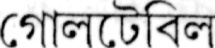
গোলটেবিল
